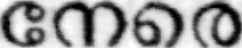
നേരെ
